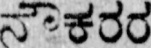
ನೌಕರರ
